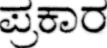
ಪ್ರಕಾರ
